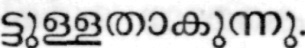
ട്ടുള്ളതാകുന്നു.
